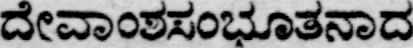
ದೇವಾಂಶಸಂಭೂತನಾದ
